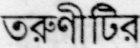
তরুণীটির
